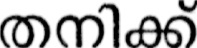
തനിക്ക്
